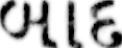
બાદ
